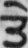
ਤੇ
